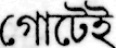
গোটেই
